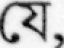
যে,
